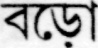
বড়ো
